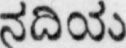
ನದಿಯ
